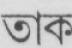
তাক
